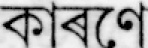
কাৰণে
